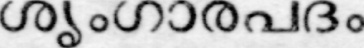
ശൃംഗാരപദം
